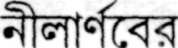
নীলার্ণবের
